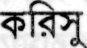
করিসু
